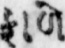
ફાળે
